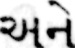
અને
